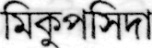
মিকুপসিদা
